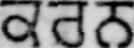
ਕਰਨ
